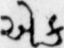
એક
